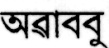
অৱাববু
